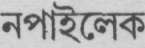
নপাইলেক
